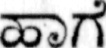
ಹಾಗೆ
